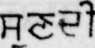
ਸੁਣਦੀ
